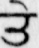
ਤੇ
